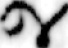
જ
